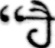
''ਹੈ
